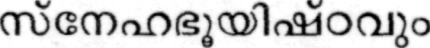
സ്നേഹഭൂയിഷ്ഠവും
